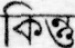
কিন্তু
